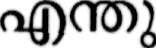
എന്തു
